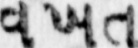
વખત
